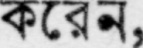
করেন,
